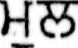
ਮੁਲ
